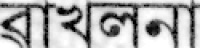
ৱাখলনা
